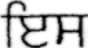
ਇਸ
